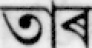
তাৰ
